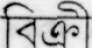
বিক্রী
